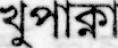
খুপাক্না
